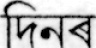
দিনৰ
